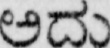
ಅದು
